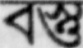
বস্তু
